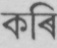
কৰি
